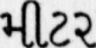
મીટર
